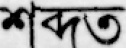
শব্দত
